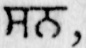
ਸਨ,
